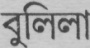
বুলিলা
